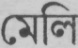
মেলি
